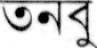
তনবু
